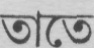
তাতে
